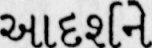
આદર્શને
